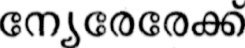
ന്യേരേരേക്ക്
